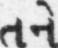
તને
